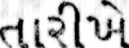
તારીખે
